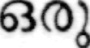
ഒരു
